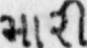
મારી
